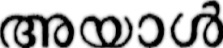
അയാള്‍
